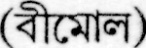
(বীমোল)
